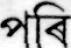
পৰি
